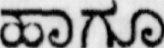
ಹಾಗೂ
